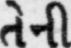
તેની
